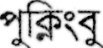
পুক্নিংবু
